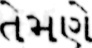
તેમણે
